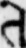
તે
